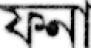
ফনা
